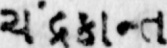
ચંદ્રકાન્ત
